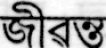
জীৱন্ত
